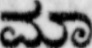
ಮಾ
